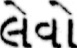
લેવો
